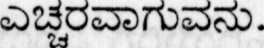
ಎಚ್ಚರವಾಗುವನು.
